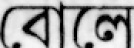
বোলে
